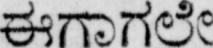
ಈಗಾಗಲೇ
